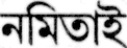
নমিতাই
